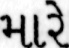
મારે
